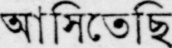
আসিতেছি
